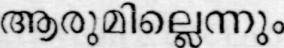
ആരുമില്ലെന്നും
